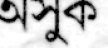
অসুক
